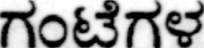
ಗಂಟೆಗಳ
